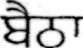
ਬੈਠਾ
